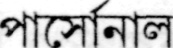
পার্সোনাল
